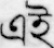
এই
